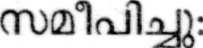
സമീപിച്ചു:
